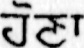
ਹੋਣਾ
